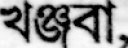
খঞ্জবী,
